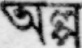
অল্প
